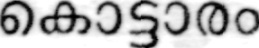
കൊട്ടാരം
